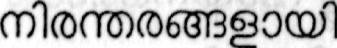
നിരന്തരങ്ങളായി
